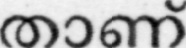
താണ്
